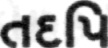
તદપિ
